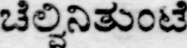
ಚೆಲ್ವಿನಿತುಂಟೆ
